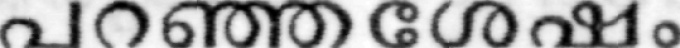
പറഞ്ഞശേഷം
